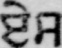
ਏਸ
